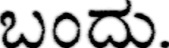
ಬಂದು.
